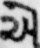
એ
